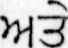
ਅਤੇ
